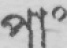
পা
